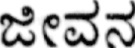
ಜೀವನ
